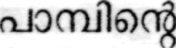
പാമ്പിന്റെ
